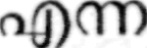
എന്ന
